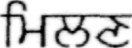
ਮਿਲਣ
